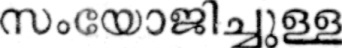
സംയോജിച്ചുള്ള
